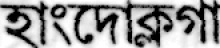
হাংদোক্লগা
